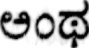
ಅಂಥ
